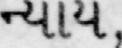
ન્યાય,
